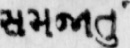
સમજાતું
